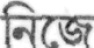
নিজে
